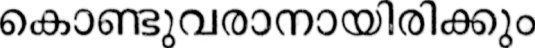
കൊണ്ടുവരാനായിരിക്കും
